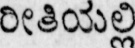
ರೀತಿಯಲ್ಲಿ
